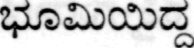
ಭೂಮಿಯಿದ್ದ
